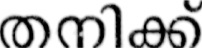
തനിക്ക്
